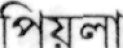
পিয়লা
